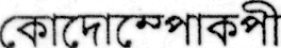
কোদোম্পোকপী
